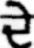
ਦੇ
